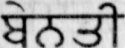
ਬੇਨਤੀ
